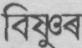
বিষ্ণুৰ
